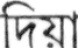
দিয়া
